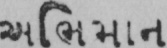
અભિમાન
